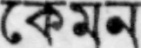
কেমন
